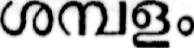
ശമ്പളം
